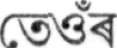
তেওঁৰ
